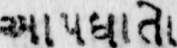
આપઘાતો
